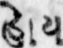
હોય
